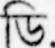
ডি.
